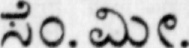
ಸೆಂ.ಮೀ.
